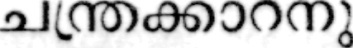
ചന്ത്രക്കാറനു
